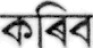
কৰিব
